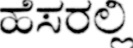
ಹೆಸರಲ್ಲಿ
